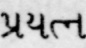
પ્રયત્ન
